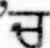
'ਚ
